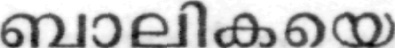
ബാലികയെ
